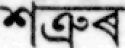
শত্রুৰ
